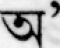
অ'
